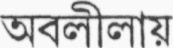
অবলীলায়
